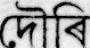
দৌৰি
